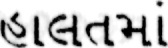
હાલતમાં
